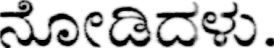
ನೋಡಿದಳು.
